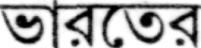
ভারতের
